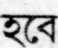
হবে
